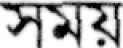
সময়
